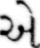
એ
